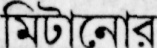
মিটানোর
